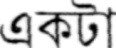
একটা
